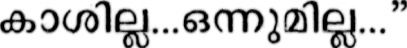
കാശില്ല...ഒന്നുമില്ല...”
